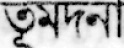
তূমদনা
